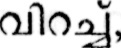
വിറച്ച്,
